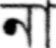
না
